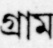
গ্রাম
